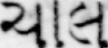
ચાલ
